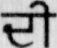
ਦੀ
